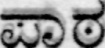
ಪಾಠ
